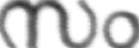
സം
